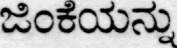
ಜಿಂಕೆಯನ್ನು
